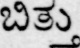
ಬಿತ್ತು
